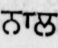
ਨਾਲ
